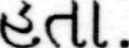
હતા.
